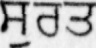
ਸੁਰਤ
